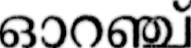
ഓറഞ്ച്
